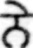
ਨੇ
